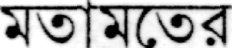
মতামতের
